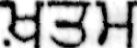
ਖ਼ਤਮ
